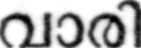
വാരി
